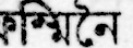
ফম্মিনৈ
